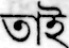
তাই
